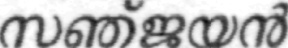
സഞ്ജയന്‍
